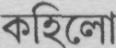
কহিলো
